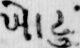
ખોટું
